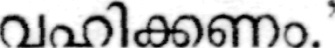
വഹിക്കണം.’
